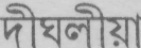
দীঘলীয়া
